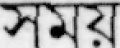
সময়
